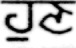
ਹੁਣ
